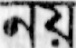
নয়
